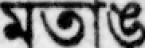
মতাঙ
